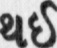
થઈ
